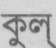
কুল্
